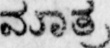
ಮಾತ್ರ
